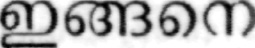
ഇങ്ങനെ
